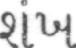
શંખ
